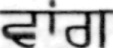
ਵਾਂਗ
